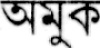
অমুক
